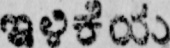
ಇಳಿಕೆಯ
